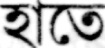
হাতে
